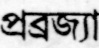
প্রব্রজ্যা
